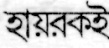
হায়রকই
